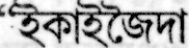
“ইকাইজৈদা
